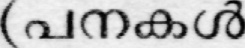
(പനകള്‍
